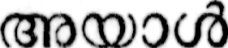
അയാള്‍
